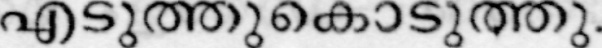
എടുത്തുകൊടുത്തു.
